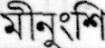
মীনুংশি
